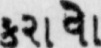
કરાવો
